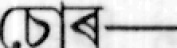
চোৰ-
